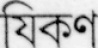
যিকণ
